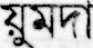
য়ুমদা
